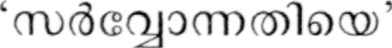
'സര്‍വ്വോന്നതിയെ'
